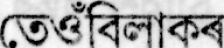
তেওঁবিলাকৰ
